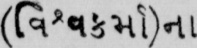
(વિશ્વકર્મા)ના
